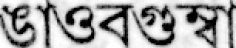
ঙাওবগুম্বা
